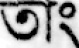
তাং
